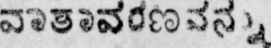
ವಾತಾವರಣವನ್ನು
